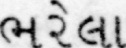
ભરેલા
